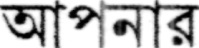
আপনার
